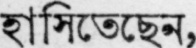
হাসিতেছেন,
